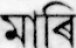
মাৰি
